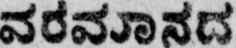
ವರಮಾನದ
